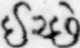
ઈચ્છે
